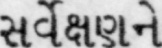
સર્વેક્ષણને
